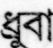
ধ্রুবা
